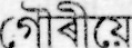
গৌৰীয়ে
